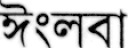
ঈংলবা
